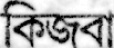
কিজবা
